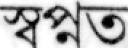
স্বপ্নত
